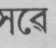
সৱে
